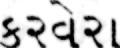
કરવેરા
